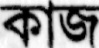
কাজ
